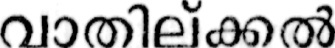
വാതില്ക്കല്‍
